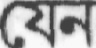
যেন
